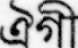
ঐগী
